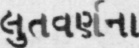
લુતવર્ણના
